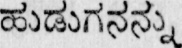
ಹುಡುಗನನ್ನು
